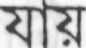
যায়
